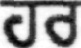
ਹਰ
